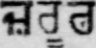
ਜ਼ਰੂਰ
